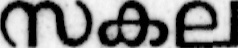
സകല
